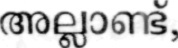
അല്ലാണ്ട്,
